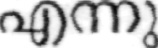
എന്നു
